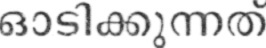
ഓടിക്കുന്നത്
